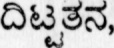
ದಿಟ್ಟತನ,
